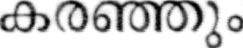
കരഞ്ഞും
